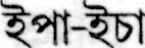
ইপা-ইচা
